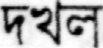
দখল
